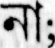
না;
